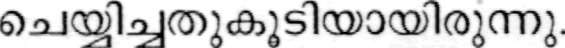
ചെയ്യിച്ചതുകൂടിയായിരുന്നു.
